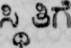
ಸ್ಥಿತಿಗೆ
